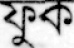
ফুক
